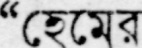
‘‘হেমের
